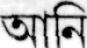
আনি
